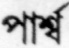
পার্শ্ব
